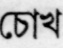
চোখ
